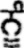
ਨੂੰ
